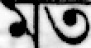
মত
